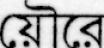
য়ৌরে
